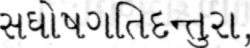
સઘોષગતિદન્તુરા,
